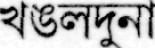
খঙলদুনা
